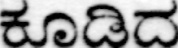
ಕೂಡಿದ
